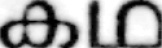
കഥ
